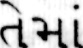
તેમાં
